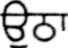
ਉਠਾ
